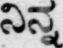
ನಿನ್ನ
